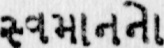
સ્વમાનનો
